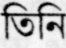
তিনি
